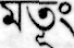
মতূং
